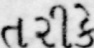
તરીકે
